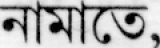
নামাতে,
